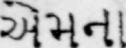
એમના
